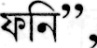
ফনি”,
